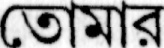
তোমার
